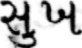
સુખ
